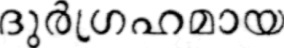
ദുര്‍ഗ്രഹമായ
